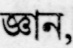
জ্ঞান,
